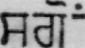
ਸਗੋਂ
